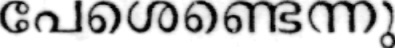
പേശെണ്ടെന്നു
